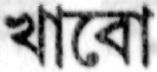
খাবো
